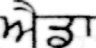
ਐਡਾ
